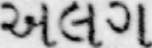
અલગ
